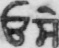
ਓਸੇ
